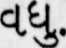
વધુ.
